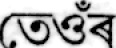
তেওঁৰ
